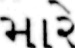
મારે
